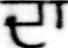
ਦਾ
